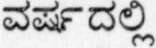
ವರ್ಷದಲ್ಲಿ
